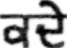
ਕਦੇ
